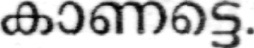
കാണട്ടെ.
